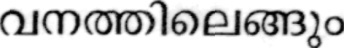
വനത്തിലെങ്ങും
